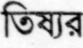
তিষ্যর
